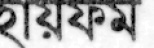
হায়ফম
